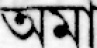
অমা
